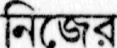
নিজের
